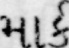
માર્ક
